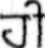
ਹੀ
